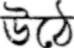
উঠে
